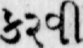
કરવી
